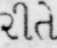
રીતે
